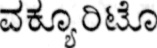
ವಕ್ಯೂರಿಟೊ
